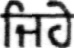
ਜਿਹੇ
